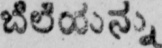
ಬೆಲೆಯನ್ನು
